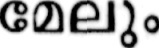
മേലും
